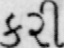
કરી
